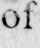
of
